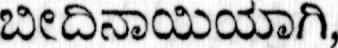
ಬೀದಿನಾಯಿಯಾಗಿ,
